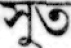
সুত
